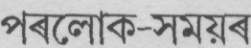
পৰলোক-সময়ৰ
